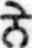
ਨੇ
